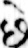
છે
